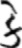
કે
